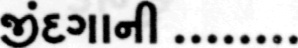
જીંદગાની........
